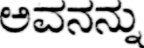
ಅವನನ್ನು
